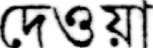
দেওয়া
